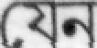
যেন
